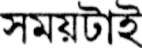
সময়টাই
